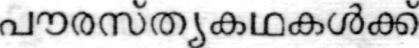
പൌരസ്ത്യകഥകള്‍ക്ക്
